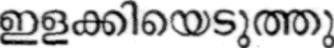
ഇളക്കിയെടുത്തു
